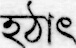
হঠাৎ
